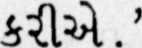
કરીએ.'
